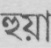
হুয়া
